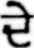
ਦੇ
